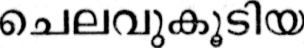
ചെലവുകൂടിയ
